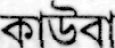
কাউবা
